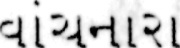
વાંચનારા
